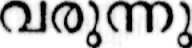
വരുന്നു
